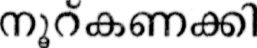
നൂറ്കണക്കി
